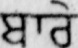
ਬਾਰੇ
